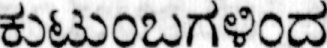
ಕುಟುಂಬಗಳಿಂದ
